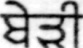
ਬੇੜੀ
